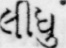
લીધું
